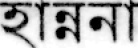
হান্ননা
